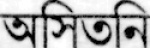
অসিতনি
